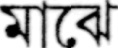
মাঝে
